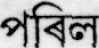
পৰিল
